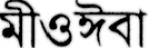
মীওঈবা
